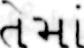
તેમાં
